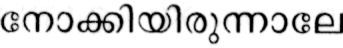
നോക്കിയിരുന്നാലേ
